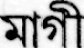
মাগী
